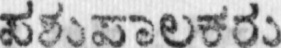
ಪಶುಪಾಲಕರು
